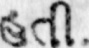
હતી.
